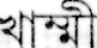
খাম্মী
